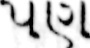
પણ
